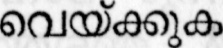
വെയ്ക്കുക
